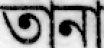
তানা
